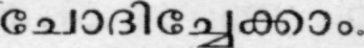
ചോദിച്ചേക്കാം.
